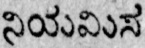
ನಿಯಮಿಸ
